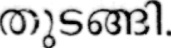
തുടങ്ങി.
